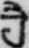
ਹੈ
